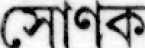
সোণক
